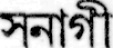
সনাগী
